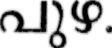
പുഴ.
